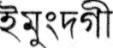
ইমুংদগী
